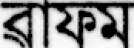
ৱাফম
